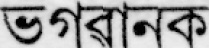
ভগৱানক
